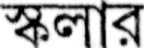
স্কলার
